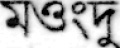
মওংদু
